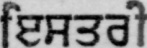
ਇਸਤਰੀ
